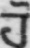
ਹੋ
